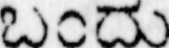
ಬಂದು
